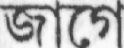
জাগে
